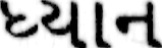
ધ્યાન
